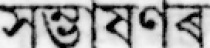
সম্ভাষণৰ
